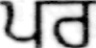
ਪਰ
